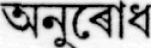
অনুৰোধ
